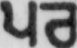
ਪਰ
